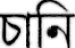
চানি
